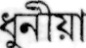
ধুনীয়া
